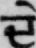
ਦੇ
